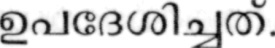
ഉപദേശിച്ചത്.
